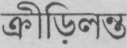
ক্ৰীড়িলন্ত
